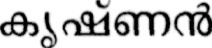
കൃഷ്ണന്‍
